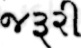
જરૂરી
